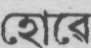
হোৱে
